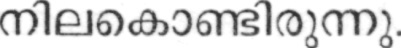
നിലകൊണ്ടിരുന്നു.
